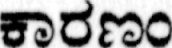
ಕಾರಣಂ
